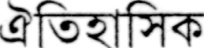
ঐতিহাসিক
